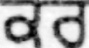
ਕਰ
